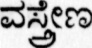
ವಸ್ತ್ರೇಣ
